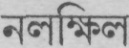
নলক্ষিল
